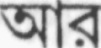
আর
